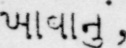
ખાવાનું,
